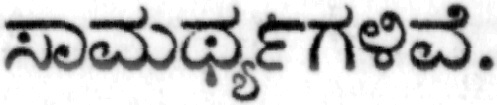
ಸಾಮ್ಮರ್ಥ್ಯಗಳಿವೆ.
